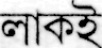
লাকই
